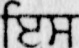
ਇਸ
